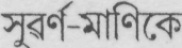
সুৱৰ্ণ-মাণিকে
